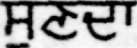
ਸੁਣਦਾ
